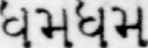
ધમધમ
